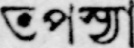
তপস্যা
